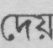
দেয়
